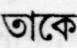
তাকে
